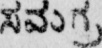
ಸಮಗ್ರ
